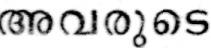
അവരുടെ
